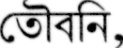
তৌবনি,
